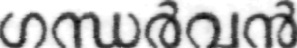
ഗന്ധര്‍വന്‍
